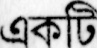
একটি
